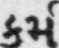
કર્મ
